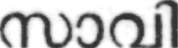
സാവി
